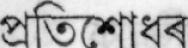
প্ৰতিশোধৰ
